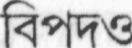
বিপদও
